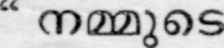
"നമ്മുടെ
